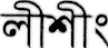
লীশীং
